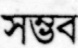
সম্ভব
